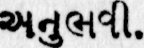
અનુભવી.
